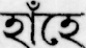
হাঁহে
